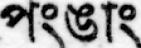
পংঙাং
